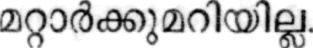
മറ്റാര്‍ക്കുമറിയില്ല.
